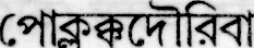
পোক্লক্কদৌরিবা
